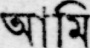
আমি
